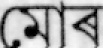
মোৰ
